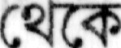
থেকে
